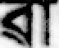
ৱা
